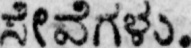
ಸೇವೆಗಳು.
